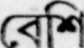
বেশি
